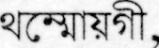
থম্মোয়গী,
